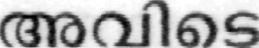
അവിടെ
